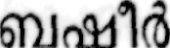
ബഷീര്‍
